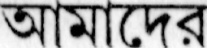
আমাদের
